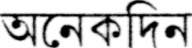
অনেকদিন
